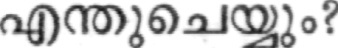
എന്തുചെയ്യും?
